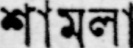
শামলা
